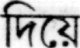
দিয়ে
